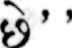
છે"
